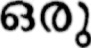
ഒരു
